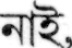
নাই,
